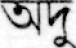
অদু
